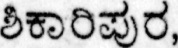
ಶಿಕಾರಿಪುರ,
